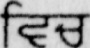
ਵਿਚ
